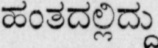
ಹಂತದಲ್ಲಿದ್ದು
